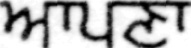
ਆਪਣਾ
